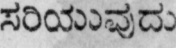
ಸರಿಯುವುದು
